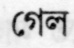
গেল
